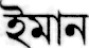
ইমান
